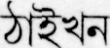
ঠাইখন
